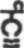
ਨੂੰ
